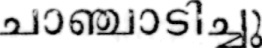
ചാഞ്ചാടിച്ചു
